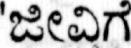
“ಜೀವಿಗೆ
